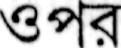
ওপর
